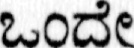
ಒಂದೇ
